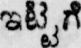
ಇಟ್ಟಿಗೆ
